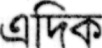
এদিক
